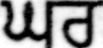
ਘਰ
